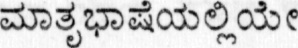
ಮಾತೃಭಾಷೆಯಲ್ಲಿಯೇ
